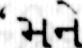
'મને
